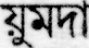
য়ুমদা
